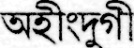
অহীংদুগী
